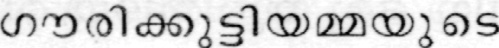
ഗൌരിക്കുട്ടിയമ്മയുടെ
